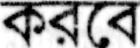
করবে
